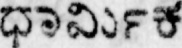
ಧಾರ್ಮಿಕ
